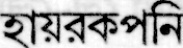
হায়রকপনি
